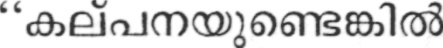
"കല്പനയുണ്ടെങ്കില്‍
